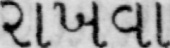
રાખવા
